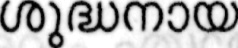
ശുദ്ധനായ
